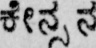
ಕೇನ್ಸನ
